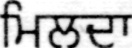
ਮਿਲਦਾ
